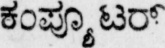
ಕಂಪ್ಯೂಟರ್
